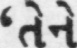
'તેને
